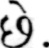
છે.
